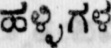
ಹಳ್ಳಿಗಳ
